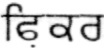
ਫ਼ਿਕਰ
